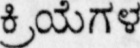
ಕ್ರಿಯೆಗಳ
